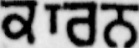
ਕਾਰਨ
